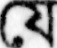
যে
